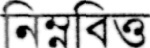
নিম্নবিত্ত
